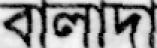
বালাদা
